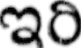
ಇರಿ
